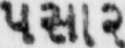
પસાર
